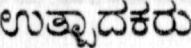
ಉತ್ಪಾದಕರು
